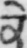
ਕੇ
